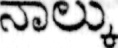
ನಾಲ್ಕು
